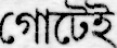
গোটেই
